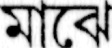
মাঝে
